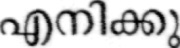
എനിക്കു
